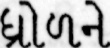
ધ્રોળને
